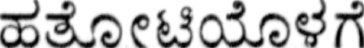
ಹತೋಟಿಯೊಳಗೆ
